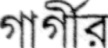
গার্গীর
